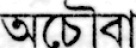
অচৌবা
